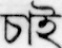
চাই
